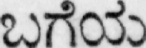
ಬಗೆಯ
